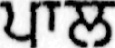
ਪਾਲ
